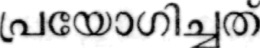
പ്രയോഗിച്ചത്
